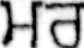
ਮਰ
